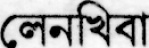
লেনখিবা
